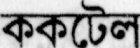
ককটেল
